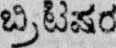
ಬ್ರಿಟಿಷರ
